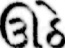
ઊઠે
